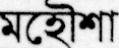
মহৌশা
